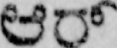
ಆರ್
